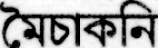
মৈচাকনি
